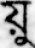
য়ু
